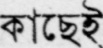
কাছেই
